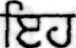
ਇਹ
